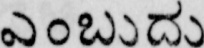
ಎಂಬುದು
